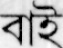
বাই
